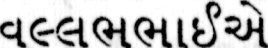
વલ્લભભાઈએ
